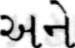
અને
